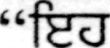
''ਇਹ
